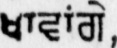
ਖਾਵਾਂਗੇ,
